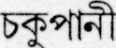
চকুপানী
